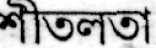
শীতলতা
